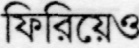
ফিরিয়েও
